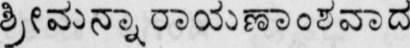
ಶ್ರೀಮನ್ನಾರಾಯಣಾಂಶವಾದ
